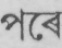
পৰে
